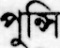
পুন্সি
